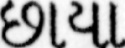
છાયા
